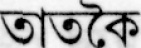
তাতকৈ
